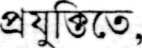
প্রযুক্তিতে,
